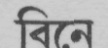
বিনে
